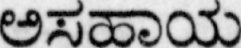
ಅಸಹಾಯ
